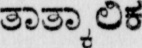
ತಾತ್ಕಾಲಿಕ
